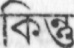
কিন্তু
